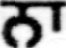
ਨਾ
